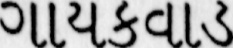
ગાયકવાડ
